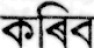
কৰিব
